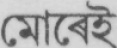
মোৰেই
